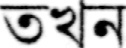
তখন
